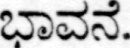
ಭಾವನೆ.
